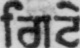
ਗਿਟੇ
